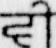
ਵੀ
